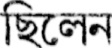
ছিলেন
